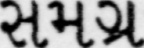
સમગ્ર
